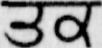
ਤਕ
